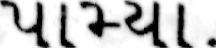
પામ્યા.
